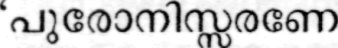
‘പുരോനിസ്സരണേ
